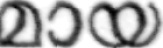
മായ
